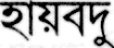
হায়বদু
